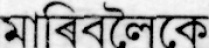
মাৰিবলৈকে
